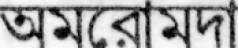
অমরোমদা
